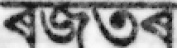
ৰজতৰ
